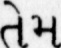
તેમ
